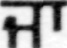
ਜਾ
